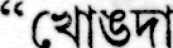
“খোঙদা
